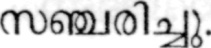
സഞ്ചരിച്ചു.
